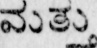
ಮತ್ತು
